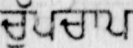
ਚੁੱਪਚਾਪ
